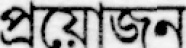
প্রয়োজন
